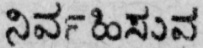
ನಿರ್ವಹಿಸುವ
